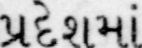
પ્રદેશમાં
